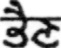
ਭੈਣ
